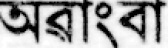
অৱাংবা
